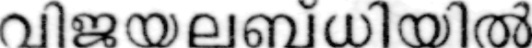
വിജയലബ്ധിയില്‍
